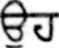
ਉਹ
